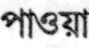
পাওয়া
